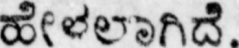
ಹೇಳಲಾಗಿದೆ.
